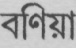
বণিয়া
